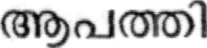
ആപത്തി
